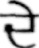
ਦੇ
